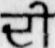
ਦੀ
